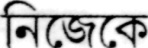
নিজেকে
